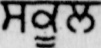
ਸਕੂਲ
